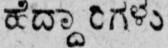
ಹೆದ್ದಾರಿಗಳು
